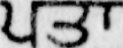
ਪਤਾ
